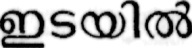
ഇടയില്‍
